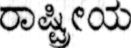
ರಾಷ್ಟ್ರೀಯ
